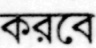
করবে
